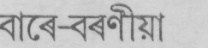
বাৰে-বৰণীয়া
